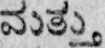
ಮತ್ತು
